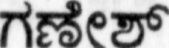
ಗಣೇಶ್
